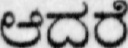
ಆದರೆ
